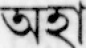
অহা
